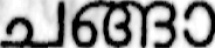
ചങ്ങാ
